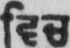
ਵਿਚ
